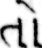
તો
